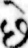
છે
